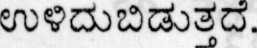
ಉಳಿದುಬಿಡುತ್ತದೆ.
